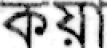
কয়া
